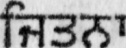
ਜਿਤਨਾ
